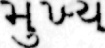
મુખ્ય
